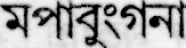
মপাবুংগনা
